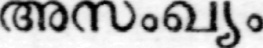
അസംഖ്യം
